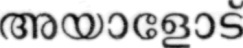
അയാളോട്
